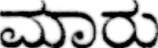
ಮಾರು
